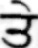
ਤੇ
